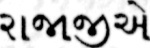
રાજાજીએ
